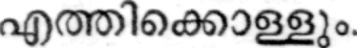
എത്തിക്കൊള്ളും.
